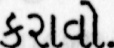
કરાવો.
